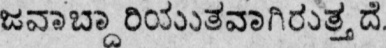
ಜವಾಬ್ದಾರಿಯುತವಾಗಿರುತ್ತದೆ.
